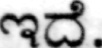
ಇದೆ.
